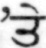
'ਤੇ
